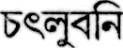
চৎলুবনি
